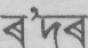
ৰ'দৰ
